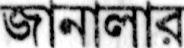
জানালার
